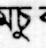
মচু
